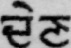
ਦੇਣ
